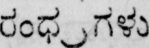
ರಂಧ್ರಗಳು
